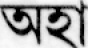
অহা
